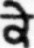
ਕੇ
